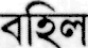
বহিল
